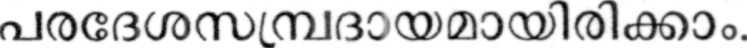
പരദേശസമ്പ്രദായമായിരിക്കാം.
